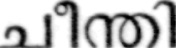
ചീന്തി
